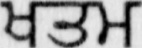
ਖਤਮ
